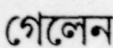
গেলেন
